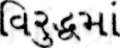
વિરુદ્ધમાં
